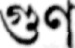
গুণ
